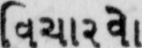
વિચારવો
